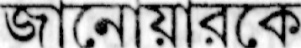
জানোয়ারকে
